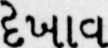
દેખાવ
